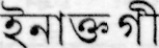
ইনাক্তগী
